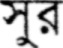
সুর
